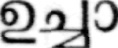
ഉച്ചാ
